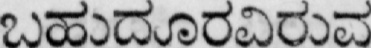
ಬಹುದೂರವಿರುವ
